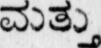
ಮತ್ತು
